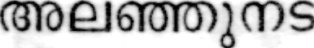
അലഞ്ഞുനട
